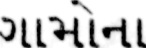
ગામોના
